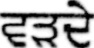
ਵੜਦੇ
